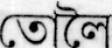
তোলৈ
